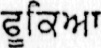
ਫੂਕਿਆ
